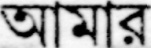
আমার
